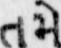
તમે
